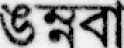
ঙম্নবা
